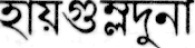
হায়গুম্লদুনা
